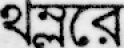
থম্লরে
